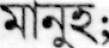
মানুহ;
